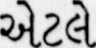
એટલે
